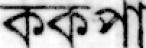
ককপা
